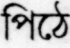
পিঠে
